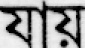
যায়
